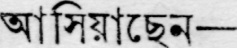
আসিয়াছেন—
